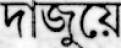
দাজুয়ে
